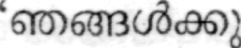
‘ഞങ്ങള്‍ക്കു
